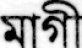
মাগী
